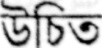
উচিত
